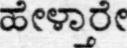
ಹೇಳ್ತಾರೇ
